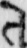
તે
